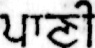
ਪਾਣੀ
